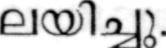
ലയിച്ചു.
